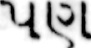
પણ
